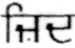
ਜ਼ਿਦ
